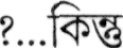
?...কিন্তু
